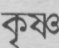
কৃষ্ণ
